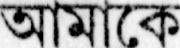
আমাকে
